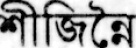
শীজিন্নৈ
